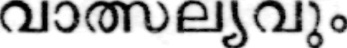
വാത്സല്യവും
